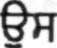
ਉਸ
